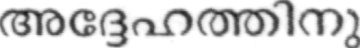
അദ്ദേഹത്തിനു
